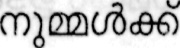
നുമ്മള്‍ക്ക്
